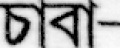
চাবা-
